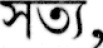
সত্য,
